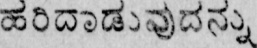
ಹರಿದಾಡುವುದನ್ನು
